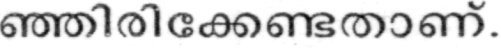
ഞ്ഞിരിക്കേണ്ടതാണ്.
